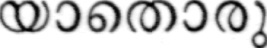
യാതൊരു
